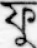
ফু
